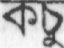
কচু
